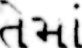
તેમાં
